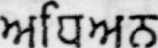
ਅਧਿਅਨ
